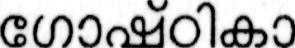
ഗോഷ്ഠികാ
